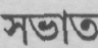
সভাত
